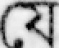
যে
